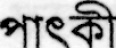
পাৎকী
